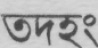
তদহং
